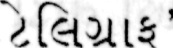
ટેલિગ્રાફ'
